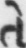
તે
